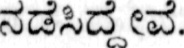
ನಡೆಸಿದ್ದೇವೆ.
